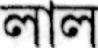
লাল
